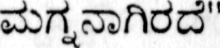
ಮಗ್ನನಾಗಿರದೆ”
